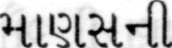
માણસની
